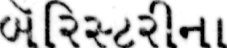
બૅરિસ્ટરીના
